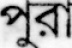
পুরা
